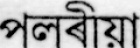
পলৰীয়া
